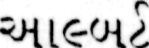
આલ્બર્ટ
